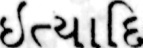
ઈત્યાદિ
